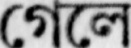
গেলে
